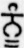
ਨੂੰ
